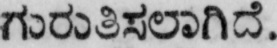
ಗುರುತಿಸಲಾಗಿದೆ.
